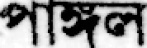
পাঙ্গল
